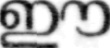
ഈ
